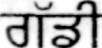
ਗੱਡੀ
